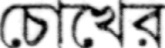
চোখের
